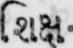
શિક્ષ-
